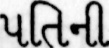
પતિની
